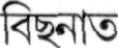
বিছনাত
